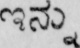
ಇನ್ನು
